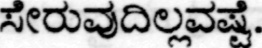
ಸೇರುವುದಿಲ್ಲವಷ್ಟೆ.
